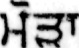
ਮੋੜਾ
